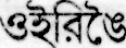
ওইরিঙৈ
